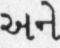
અને
